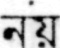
নয়
